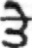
ਤੇ
